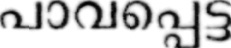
പാവപ്പെട്ട
